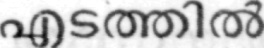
എടത്തില്‍
